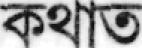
কথাত
